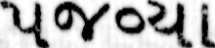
પજવ્યા
